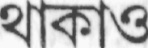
থাকাও
